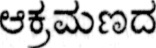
ಆಕ್ರಮಣದ
